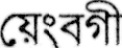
য়েংবগী
